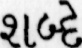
શબ્દે
